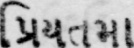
પ્રિયતમા
